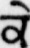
ਕੇ
